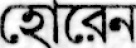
হোরেন
